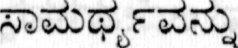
ಸಾಮರ್ಥ್ಯವನ್ನು
